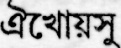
ঐখোয়সু
